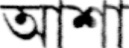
আশা
